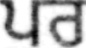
ਪਰ
